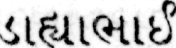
ડાહ્યાભાઈ
